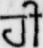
ਹੀ
